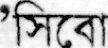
’সিবো
